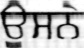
ਉਸਨੇ
